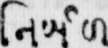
નિર્બળ
